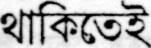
থাকিতেই
